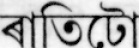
ৰাতিটো
